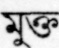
মুক্ত
